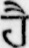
ਹੈ
